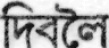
দিবলৈ
